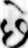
છે
